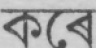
কৰে
